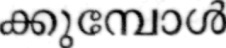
ക്കുമ്പോള്‍
